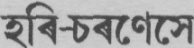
হৰি-চৰণেসে
